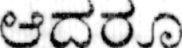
ಆದರೂ
